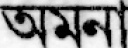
অমনা
